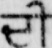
ਦੀ
